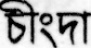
চীংদা
